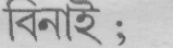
বিনাই;
